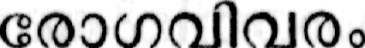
രോഗവിവരം
